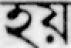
হয়
